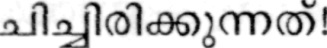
ചിച്ചിരിക്കുന്നത്!
